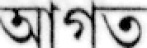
আগত
